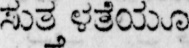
ಸುತ್ತಳತೆಯೂ
